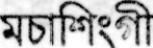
মচাশিংগী
